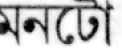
মনটো
